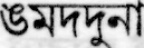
ঙমদদুনা
